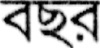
বছর
